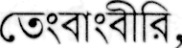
তেংবাংবীরি,
